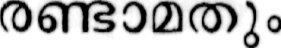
രണ്ടാതും
